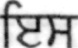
ਇਸ
